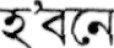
হ'বনে
